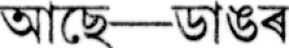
আছে-ডাঙৰ
